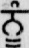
ਨੂੰ
